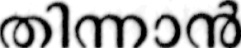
തിന്നാന്‍
